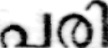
പരി
